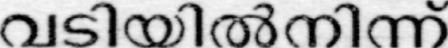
വടിയില്‍നിന്ന്
